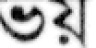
ভয়
